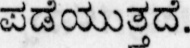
ಪಡೆಯುತ್ತದೆ.
